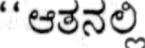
"ಆತನಲ್ಲಿ
